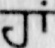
ਹਾਂ
